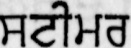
ਸਟੀਮਰ
